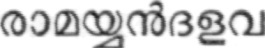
രാമയ്യന്‍ദളവ
